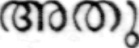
അതു
